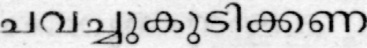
ചവച്ചുകുടിക്കണ
